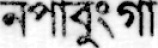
নপাবুংগা
